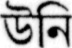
উনি
